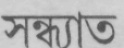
সন্ধ্যাত
